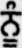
ਨੂੰ
